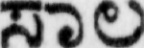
ಸಾಲ
